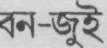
বন-জুই
